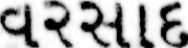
વરસાદ
